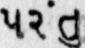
પરંતુ
